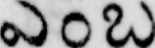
ಎಂಬ
